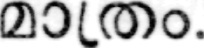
മാത്രം.
